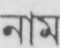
নাম
